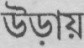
উড়ায়
